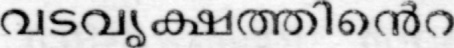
വടവൃക്ഷത്തിന്റെ
